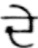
ਦੇ
